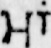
ਮਾਂ
